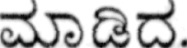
ಮಾಡಿದ.
